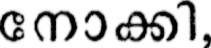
നോക്കി,
